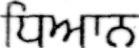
ਧਿਆਨ
